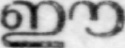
ഈ
